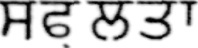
ਸਫ਼ਲਤਾ
